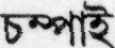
চম্পাই
